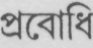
প্ৰবোধি
